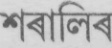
শৰালিৰ
